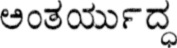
ಅಂತರ್ಯುದ್ಧ
